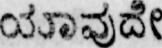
ಯಾವುದೇ
